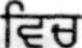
ਵਿਚ
